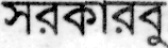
সরকারবু
